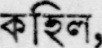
কহিল,
